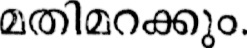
മതിമറക്കും.
